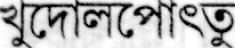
খুদোলপোৎতু
